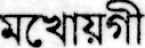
মখোয়গী
